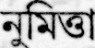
নুমিত্তা
